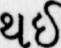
થઈ
